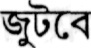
জুটবে
